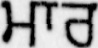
ਮਾਰ
